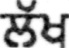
ਲੱਖ
